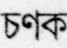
চণক
